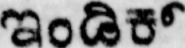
ಇಂಡಿಕ್
